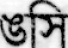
ঙসি
